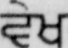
ਵੇਖ
